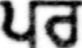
ਪਰ
